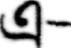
এ-
